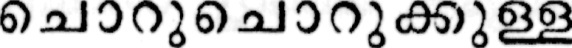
ചൊറുചൊറുക്കുള്ള
